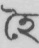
হৈ
